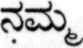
ನಮ್ಮ
